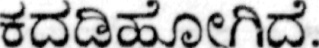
ಕದಡಿಹೋಗಿದೆ.
